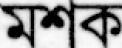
মশক
